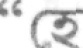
"হে
